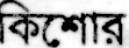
কিশোর
